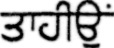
ਤਾਹੀਉਂ
